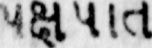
પક્ષપાત
